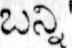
ಬನ್ನಿ
